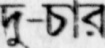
দু-চার
